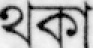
থকা
